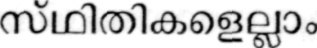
സ്ഥിതികളെല്ലാം
